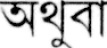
অথুবা
